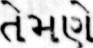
તેમણે
